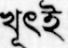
খূৎই
